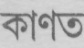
কাণত
